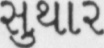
સુથાર
